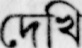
দেখি
